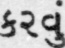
કરવું
